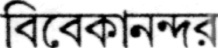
বিবেকানন্দর
